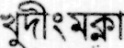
খুদীংমক্না
